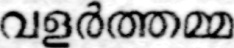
വളര്‍ത്തമ്മ
